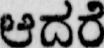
ಆದರೆ
